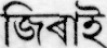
জিৰাই
